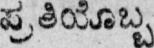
ಪ್ರತಿಯೊಬ್ಬ
